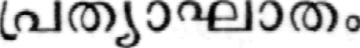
പ്രത്യാഘാതം
